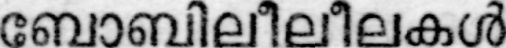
ബോബിലീലീലകള്‍
